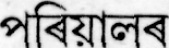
পৰিয়ালৰ
